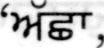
'ਅੱਛਾ,
